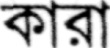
কারা
